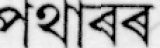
পথাৰৰ
